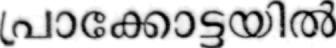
പ്രാക്കോട്ടയില്‍
